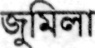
জুমিলা
